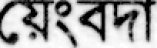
য়েংবদা
